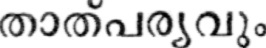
താത്പര്യവും
